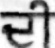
ਦੀ
